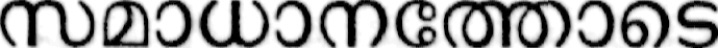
സമാധാനത്തോടെ
